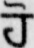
ਹੋ
